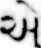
એ
